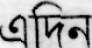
এদিন
